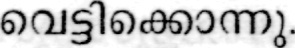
വെട്ടിക്കൊന്നു.
